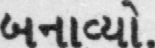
બનાવ્યો.
